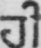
ਹੀ
